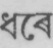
ধৰে
